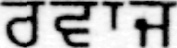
ਰਵਾਜ
